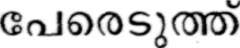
പേരെടുത്ത്
